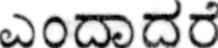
ಎಂದಾದರೆ
